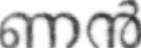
ണന്‍
